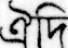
ঐদি
